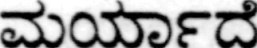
ಮರ್ಯಾದೆ
